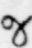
જ
